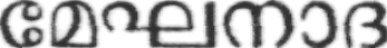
മേഘനാദ
